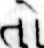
તો
